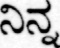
ನಿನ್ನ
